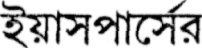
ইয়াসপার্সের
